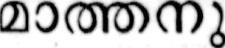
മാത്തനു
